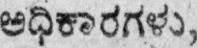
ಅಧಿಕಾರಗಳು,
